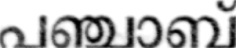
പഞ്ചാബ്
